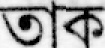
তাক
